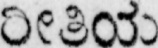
ರೀತಿಯ
